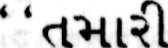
"તમારી
